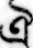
ঐ
